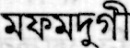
মফমদুগী
